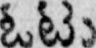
ಓಟು
